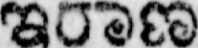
ಇರಾಣ
